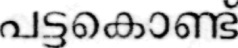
പട്ടകൊണ്ട്
